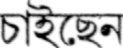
চাইছেন
